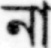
না
